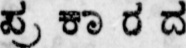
ಪ್ರಕಾರದ
